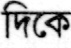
দিকে
